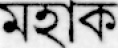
মহাক
